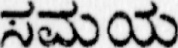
ಸಮಯ
